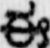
ಈ
